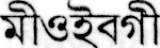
মীওইবগী
